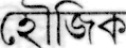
হৌজিক
